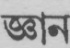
জ্ঞান
